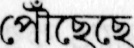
পৌঁছেছে
